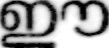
ഈ
